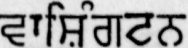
ਵਾਸ਼ਿੰਗਟਨ
